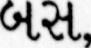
બસ,
